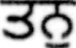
ਤਨੁ
